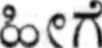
ಹೀಗೆ
